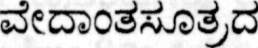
ವೇದಾಂತಸೂತ್ರದ
